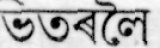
ভিতৰলৈ
